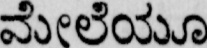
ಮೇಲೆಯೂ
